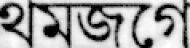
থমজগে
